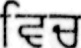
ਵਿਚ
